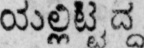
ಯಲ್ಲಿಟ್ಟಿದ್ದ
